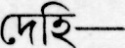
দেহি-
